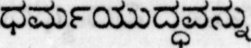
ಧರ್ಮಯುದ್ಧವನ್ನು
